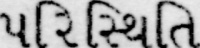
પરિસ્થિતિ
